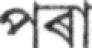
পৰা
